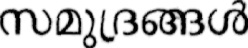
സമുദ്രങ്ങള്‍
